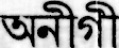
অনীগী
